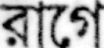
রাগে
